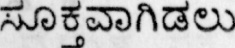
ಸೂಕ್ತವಾಗಿಡಲು
